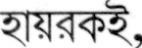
হায়রকই,
